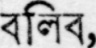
বলিব,
